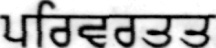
ਪਰਿਵਰਤਤ
